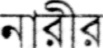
নারীর
